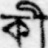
কী
